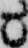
ರ
